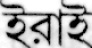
ইরাই
